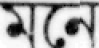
মনে
